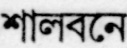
শালবনে
